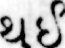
થઈ
